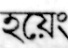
হয়েং
